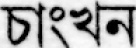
চাংখন
